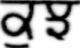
ਕੁਝ
